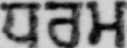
ਧਰਮ
